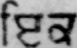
ਇਕ
